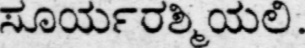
ಸೂರ್ಯರಶ್ಮಿಯಲಿ.
